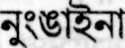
নুংঙাইনা
